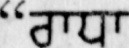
''ਰਾਧਾ
